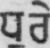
ਧੁਰੇ
